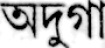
অদুগা
